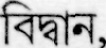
বিদ্বান,
